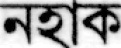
নহাক
